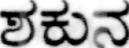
ಶಕುನ
